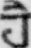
ਹੈ
